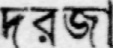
দরজা
